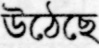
উঠেছে
